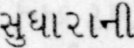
સુધારાની
